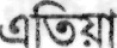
এতিয়া
